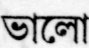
ভালো
